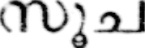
സൂച
